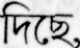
দিছে,
